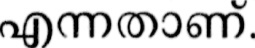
എന്നതാണ്.
